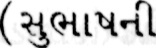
(સુભાષની
